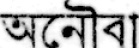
অনৌবা
